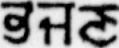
ਭਜਣ
